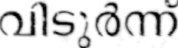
വിടുര്‍ന്ന്
